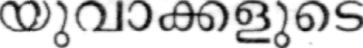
യുവാക്കളുടെ
